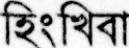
হিংখিবা
